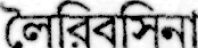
লৈরিবনসিনা
